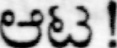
ಆಟ!
